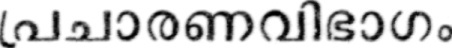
പ്രചാരണവിഭാഗം
